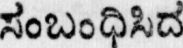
ಸಂಬಂಧಿಸಿದ
